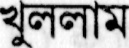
খুললাম
